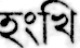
হংখি
